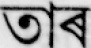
তাৰ
